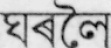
ঘৰলৈ
